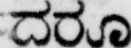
ದರೂ
